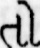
તો
